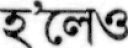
হ'লেও
